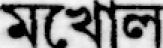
মখোল
